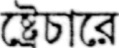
ষ্ট্রেচারে
